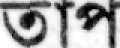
তাপ
